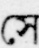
সে
